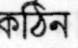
কঠিন
